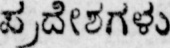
ಪ್ರದೇಶಗಳು
